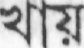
খায়
